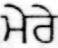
ਮੇਰੇ
